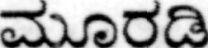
ಮೂರಡಿ
